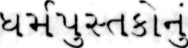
ધર્મપુસ્તકોનું
